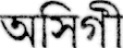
অসিগী
